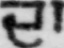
ਦਾ
